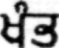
ਖੰਭ
